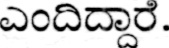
ಎಂದಿದ್ದಾರೆ.
